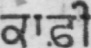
ਕਾਫ਼ੀ
